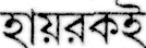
হায়রকই
